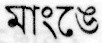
মাংঙে
